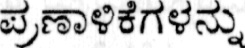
ಪ್ರಣಾಳಿಕೆಗಳನ್ನು
